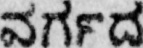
ವರ್ಗದ
